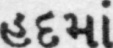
હદમાં
